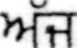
ਅੱਜ
